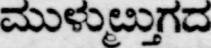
ಮುಳ್ಮುೞ್ತುಗದ
